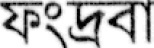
ফংদ্রবা
